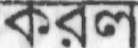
করল
